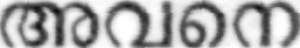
അവനെ
